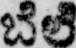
ಬೆಲೆ
